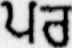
ਪਰ
